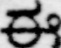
ಈ
